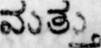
ಮತ್ತು
